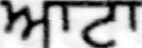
ਆਟਾ
